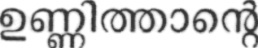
ഉണ്ണിത്താന്റെ
